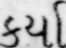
કર્યા
